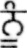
ਨੂੰ
